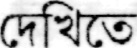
দেখিতে
